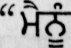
''ਮੈਨੂੰ
